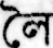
লৈ
